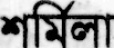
শর্মিলা
